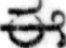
ಈ
